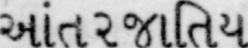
આંતરજાતિય
